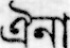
ঐনা
